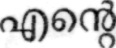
എന്റെ
